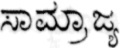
ಸಾಮ್ರಾಜ್ಯ
